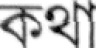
কথা
